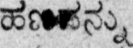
ಹಣವನ್ನು
